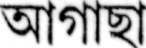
আগাছা
